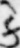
કે
